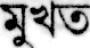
মুখত
